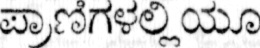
ಪ್ರಾಣಿಗಳಲ್ಲಿಯೂ
